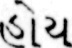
હોય
